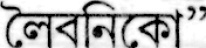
লৈবনিকো”
